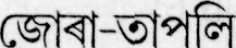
জোৰা-তাপলি
